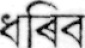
ধৰিব
